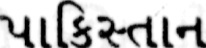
પાકિસ્તાન
